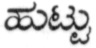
ಹುಟ್ಟು
